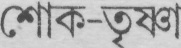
শোক-তৃষ্ণা
